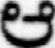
ಆ
